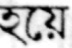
হয়ে
